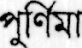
পুর্ণিমা
